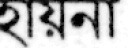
হায়না
